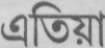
এতিয়া
